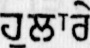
ਹੁਲਾਰੇ
